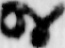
જ
